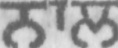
ਨਾਲ
